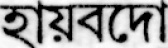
হায়বদো
